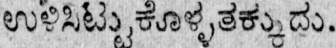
ಉಳಿಸಿಟ್ಟುಕೊಳ್ಳತಕ್ಕುದು.
